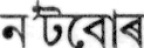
ন'টবোৰ
